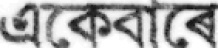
একেবাৰে
